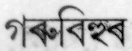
গৰুবিহুৰ
